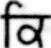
ਕਿ
